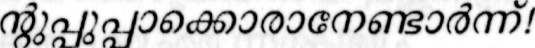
ന്റുപ്പുപ്പാക്കൊരാനേണ്ടാര്‍ന്ന്!
